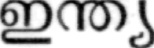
ഇന്ത്യ
